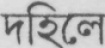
দহিলে
